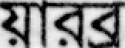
য়ারব্র
